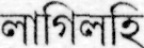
লাগিলহি
